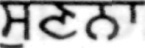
ਸੁਣਨਾ
